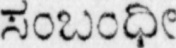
ಸಂಬಂಧೀ
